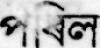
পৰিল
